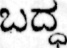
ಬದ್ಧ
